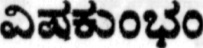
ವಿಷಕುಂಭಂ
